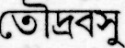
তৌদ্রবসু
